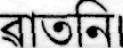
ৱাতনি।
